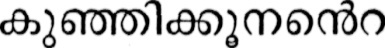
കുഞ്ഞിക്കൂനന്റെ
